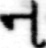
ન
